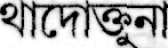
থাদোক্তুনা
